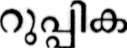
റുപ്പിക
